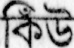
কিঁউ
